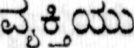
ವ್ಯಕ್ತಿಯು
